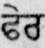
ਫੇਰ
